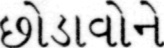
છોડાવોને
